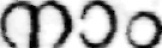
നാം
